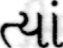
ત્યાં
